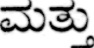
ಮತ್ತು
